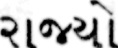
રાજ્યો
